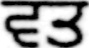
ਵਤ
